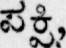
ಪಕ್ಷಿ,
